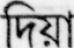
দিয়া
